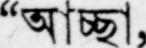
‘‘আচ্ছা,
